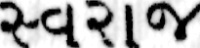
સ્વરાજ
